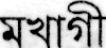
মখাগী
